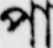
পা
